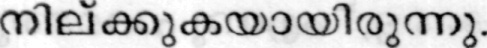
നില്ക്കുകയായിരുന്നു.
